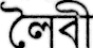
লৈবী
